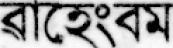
ৱাহেংবম
